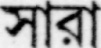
সারা
